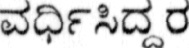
ವರ್ಧಿಸಿದ್ದರ
